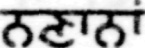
ਨਣਾਨਾਂ
